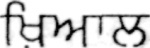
ਖ਼ਿਆਲ
